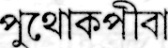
পুথোকপীবা
